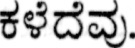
ಕಳೆದೆವು.
